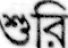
শুরি
